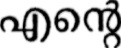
എന്റെ
